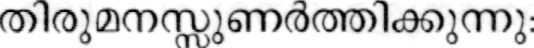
തിരുമനസ്സുണര്‍ത്തിക്കുന്നു:
